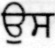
ਉਸ
